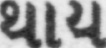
થાય
